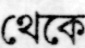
থেকে
